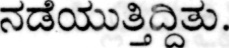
ನಡೆಯುತ್ತಿದ್ದಿತು.
